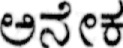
ಅನೇಕ
